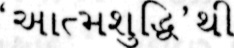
'આત્મશુદ્ધિ'થી
